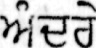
ਅੰਦਰੇ
